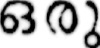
ഒരു
